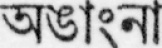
অঙাংনা
